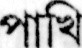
পাখি
